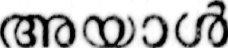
അയാള്‍
